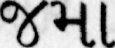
જમા
